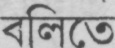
বলিতে
